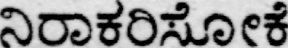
ನಿರಾಕರಿಸೋಕೆ
